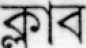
ক্লাব
